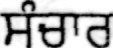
ਸੰਚਾਰ
